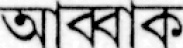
আব্বাক
